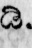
ಡಿ.
